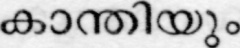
കാന്തിയും
